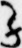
કે
